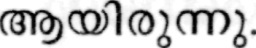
ആയിരുന്നു.
